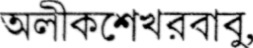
অলীকশেখরবাবু,
